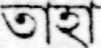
তাহা
